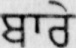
ਬਾਰੇ
